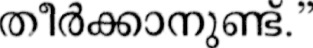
തീര്‍ക്കാനുണ്ട്.”
